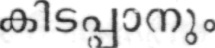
കിടപ്പാനും
